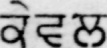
ਕੇਵਲ
